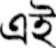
এই
